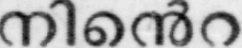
നിന്റെ
